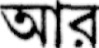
আর
